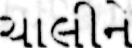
ચાલીને
